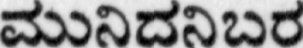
ಮುನಿದನಿಬರ
